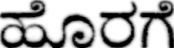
ಹೊರಗೆ
